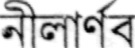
নীলার্ণব
